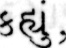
કહ્યું,
